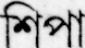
শিপা
